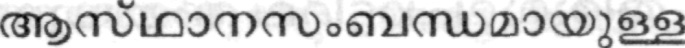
ആസ്ഥാനസംബന്ധമായുള്ള
